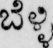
ಬೆಳ್ಳಿ
